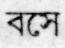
বসে
